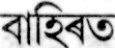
বাহিৰত
